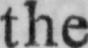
the
